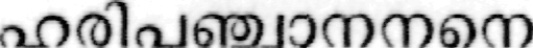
ഹരിപഞ്ചാനനനെ
